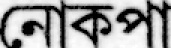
নোকপা
